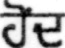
ਹੋਂਦ
